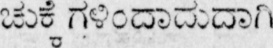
ಚುಕ್ಕೆಗಳಿಂದಾದುದಾಗಿ
